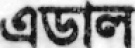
এডাল
